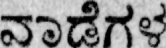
ವಾಡೆಗಳ
